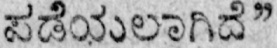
ಪಡೆಯಲಾಗಿದೆ”
